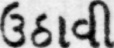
ઉઠાવી
